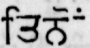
ਤਿਨੋਂ
